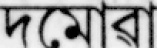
দমোৱা
